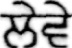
ਲੇਵੇ
